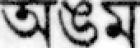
অঙম
